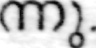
ന്നു.
